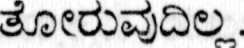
ತೋರುವುದಿಲ್ಲ.
